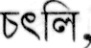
চৎলি,
